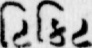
ટિકિટ
